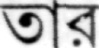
তার
